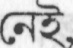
নেই,
